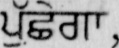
ਪੁੱਛੇਗਾ,
